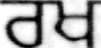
ਰਖ
